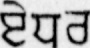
ਏਧਰ
